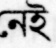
নেই
